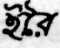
ইরৈ
